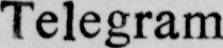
Telegram
